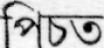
পিচত
